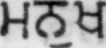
ਮਨੁਖ
